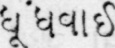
ધૂંધવાઈ
